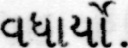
વધાર્યો.
